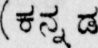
(ಕನ್ನಡ
